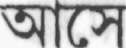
আসে
